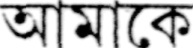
আমাকে
